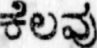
ಕೆಲವು
